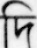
দি
